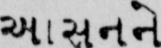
આસનને
